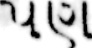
પણ
